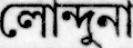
লোন্দুনা
